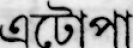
এটোপা
